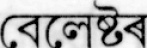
বেলেষ্টৰ
